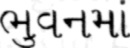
ભુવનમાં
